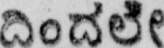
ದಿಂದಲೇ
